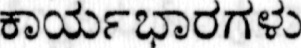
ಕಾರ್ಯಭಾರಗಳು
